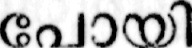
പോയി
